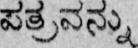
ಪತ್ರವನ್ನು
